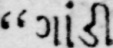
"ગાંડી
